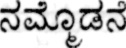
ನಮ್ಮೊಡನೆ
